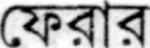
ফেরার
